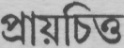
প্ৰায়চিত্ত
